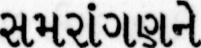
સમરાંગણને
